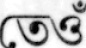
তেওঁ
